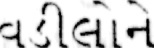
વડીલોને
